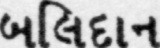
બલિદાન
